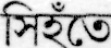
সিহঁতে
